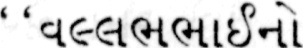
"વલ્લભભાઈનો
